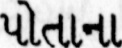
પોતાના
